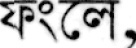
ফংলে,
